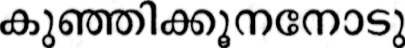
കുഞ്ഞിക്കൂനനോടു
